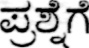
ಪ್ರಶ್ನೆಗೆ
